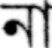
না
